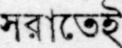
সরাতেই
